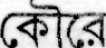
কৌরে
